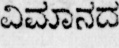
ವಿಮಾನದ
